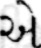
એ
